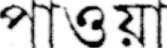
পাওয়া
